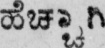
ಹೆಚ್ಚಾಗಿ
